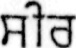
ਸੀਰ
